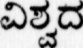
ವಿಶ್ವದ
